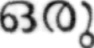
ഒരു
